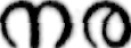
നര
